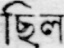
ছিল
